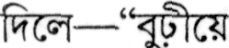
দিলে-"বুঢ়ীয়ে
